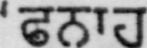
'ਫਨਾਹ
